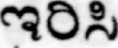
ಇರಿಸಿ
